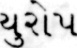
યુરોપ
